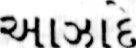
આઝાદે
